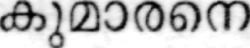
കുമാരനെ
